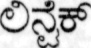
ಲಿನ್ಟೆಕ್
